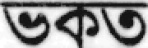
ভকত
